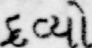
દ્રવ્યો
